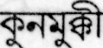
কুনমুক্কী
